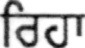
ਰਿਹਾ
